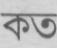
কত
